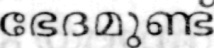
ഭേദമുണ്ട്
